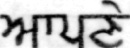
ਆਪਣੇ
